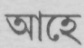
আহে
